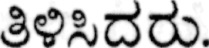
ತಿಳಿಸಿದರು.
